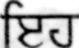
ਇਹ
